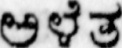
ಅಳೆತ
